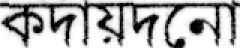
কদায়দনো
